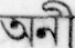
অনী
